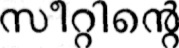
സീറ്റിന്റെ
